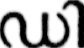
ഡി
